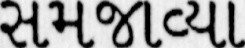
સમજાવ્યા
